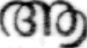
ആ
